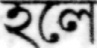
হলে
